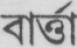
বাৰ্ত্তা
